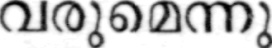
വരുമെന്നു
